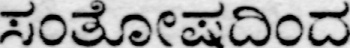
ಸಂತೋಷದಿಂದ
